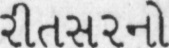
રીતસરનો
